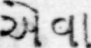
એવા
